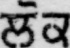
ਲੋਕ
